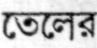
তেলের
